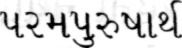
પરમપુરુષાર્થ
